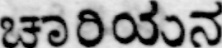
ಚಾರಿಯನ
